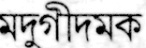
মদুগীদমক
